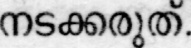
നടക്കരുത്.
